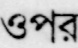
ওপর
